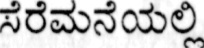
ಸೆರೆಮನೆಯಲ್ಲಿ
